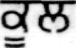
ਕੂਲ
